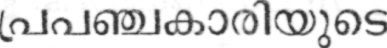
പ്രപഞ്ചകാരിയുടെ
